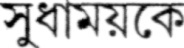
সুধাময়কে
